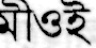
মীওই
